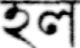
হল
